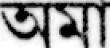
অমা
